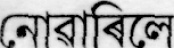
নোৱাৰিলে
